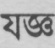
যজ্ঞ
